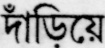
দাঁড়িয়ে
